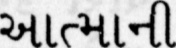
આત્માની
